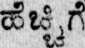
ಹೆಚ್ಚಿಗೆ
